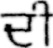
ਦੀ
